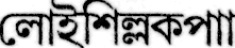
লোইশিল্লকপা
